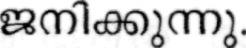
ജനിക്കുന്നു.
